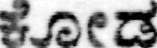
ಕೋಡ
